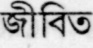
জীবিত
